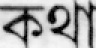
কথা
